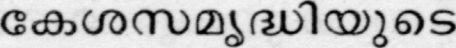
കേശസമൃദ്ധിയുടെ
